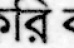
করি
